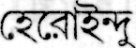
হেরোইন্দু
